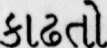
કાઢતો
